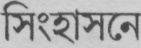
সিংহাসনে
